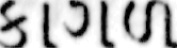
કાગળ
